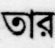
তার
